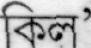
কিল'
